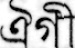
ঐগী
